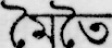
মৈতৈ
